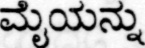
ಮೈಯನ್ನು
